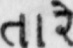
તારે
